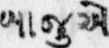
બાજુએ
